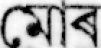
মোৰ
